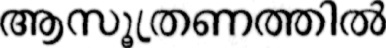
ആസൂത്രണത്തില്‍
